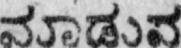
ಮಾಡುವ
